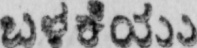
ಬಳಕೆಯು
